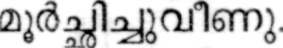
മൂര്‍ച്ഛിച്ചുവീണു.
